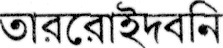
তাররোইদবনি
